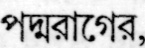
পদ্মরাগের,
